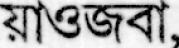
য়াওজবা,
